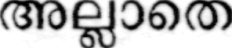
അല്ലാതെ
